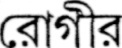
রোগীর
